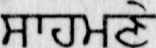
ਸਾਹਮਣੇ
